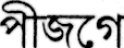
পীজগে
